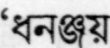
‘ধনঞ্জয়
